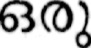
ഒരു
